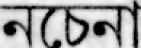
নচেনা
